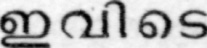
ഇവിടെ
